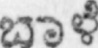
ಬಾಳೆ
